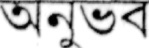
অনুভব
